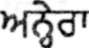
ਅਨ੍ਹੇਰਾ
